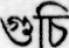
গুচি
